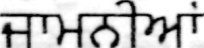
ਜਾਮਨੀਆਂ
